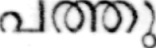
പത്തു
